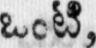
ಒಂಟೆ,
